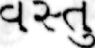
વસ્તુ
